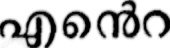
എന്റെ
